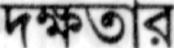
দক্ষতার
